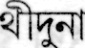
থীদুনা
